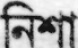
নিশা
